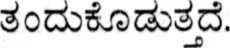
ತಂದುಕೊಡುತ್ತದೆ.
